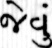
જેવું
